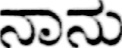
ನಾನು
